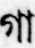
গা
